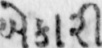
બેકારી
